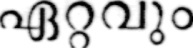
ഏറ്റവും
